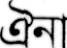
ঐনা
